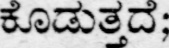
ಕೊಡುತ್ತದೆ;
